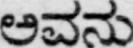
ಅವನು
